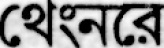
থেংনরে
